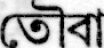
তৌবা
